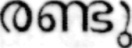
രണ്ടു
